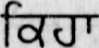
ਕਿਹਾ
